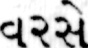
વરસે
